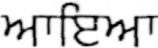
ਆਇਆ
